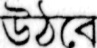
উঠবে
